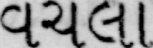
વચલા
